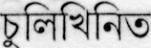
চুলিখিনিত
